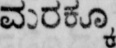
ಮರಕ್ಕೂ
